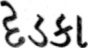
દેડકા
